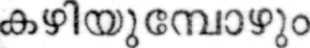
കഴിയുമ്പോഴും
